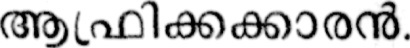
ആഫ്രിക്കക്കാരന്‍.
